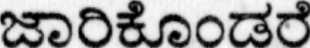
ಜಾರಿಕೊಂಡರೆ
